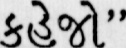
કહેજો"
